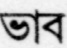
ভাব
